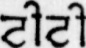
ਟੀਟੀ
